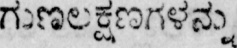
ಗುಣಲಕ್ಷಣಗಳನ್ನು
